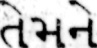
તેમને
